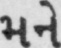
મને
